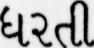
ધરતી
